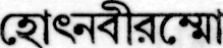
হোৎনবীরম্মো
